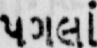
પગલાં
